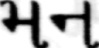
મન
